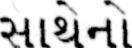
સાથેનો
